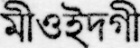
মীওইদগী
